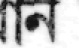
ধান
